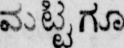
ಮಟ್ಟಿಗೂ
